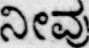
ನೀವು
